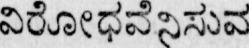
ವಿರೋಧವೆನಿಸುವ
